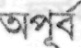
অপূৰ্ব
